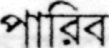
পারিব
